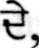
ਦੇ,
